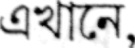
এখানে,
